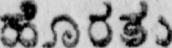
ಹೊರತು
